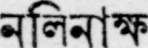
নলিনাক্ষ
